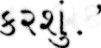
કરશું.'
